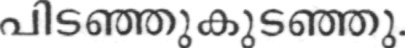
പിടഞ്ഞുകുടഞ്ഞു.
